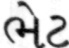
ભેટ
